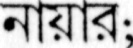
নায়ার;
